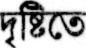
দৃষ্টিতে
